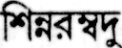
শিন্নরম্বদু
